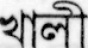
খালী
